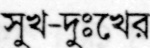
সুখ-দুঃখের
